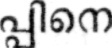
പ്പിനെ
